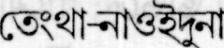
তেংথা-নাওইদুনা
